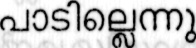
പാടില്ലെന്നു
